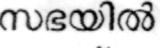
സഭയില്‍
